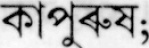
কাপুৰুষ;
